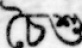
চৈশু
